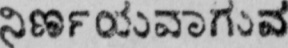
ನಿರ್ಣಯವಾಗುವ
